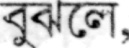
বুঝলে,
